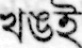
খঙই
